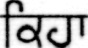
ਕਿਹਾ
